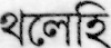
থলেহি
